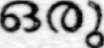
ഒരു
